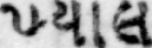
ખ્યાલ
